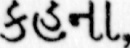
કહના,
